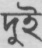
দুই
